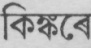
কিঙ্কৰে
